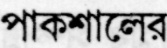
পাকশালের
